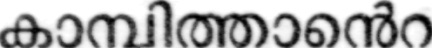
കാമ്പിത്താന്റെ
